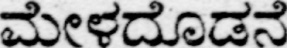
ಮೇಳದೊಡನೆ
